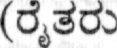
(ರೈತರು
